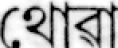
থোৱা
